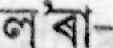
ল'ৰা-
